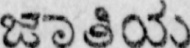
ಜಾತಿಯ
